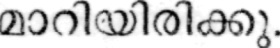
മാറിയിരിക്കു.
